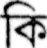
কি
